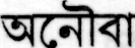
অনৌবা
